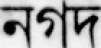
নগদ
